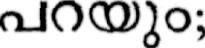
പറയും;
